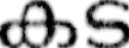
കട
